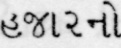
હજારનો
